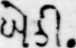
બેઠી.
